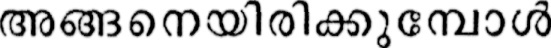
അങ്ങനെയിരിക്കുമ്പോള്‍
